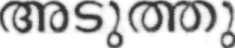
അടുത്തു
